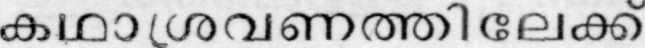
കഥാശ്രവണത്തിലേക്ക്
